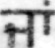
ਜਾਂ
